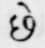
છે
